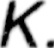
K.
